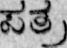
ಪತ್ರ
